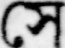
সে
